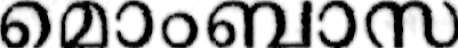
മൊംബാസ
